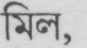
মিল,
